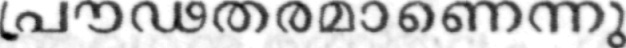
പ്രൌഢതരമാണെന്നു
